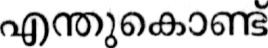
എന്തുകൊണ്ട്
